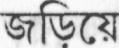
জড়িয়ে
